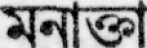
মনাক্তা
